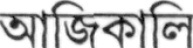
আজিকালি
